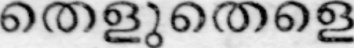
തെളുതെളെ
